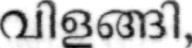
വിളങ്ങി,
